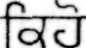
ਕਿਹੋ
